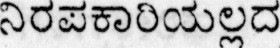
ನಿರಪಕಾರಿಯಲ್ಲದ
